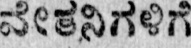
ವೇತನಿಗಳಿಗೆ
